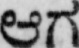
ಆಗ
